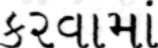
કરવામાં
